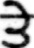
ਤੇ
